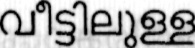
വീട്ടിലുള്ള
